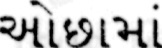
ઓછામાં
